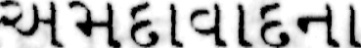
અમદાવાદના
